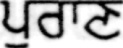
ਪੁਰਾਣ
